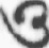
ও
